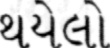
થયેલો
